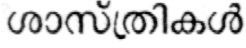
ശാസ്ത്രികള്‍
